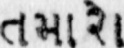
તમારો
